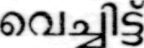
വെച്ചിട്ട്
